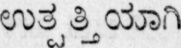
ಉತ್ಪತ್ತಿಯಾಗಿ
